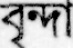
বৃন্দা
